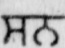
ਸਨ
